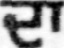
ਦਾ
